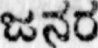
ಜನರ
